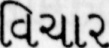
વિચાર
